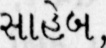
સાહેબ,
